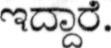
ಇದ್ದಾರೆ.
